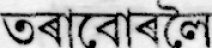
তৰাবোৰলৈ
